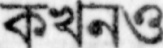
কখনও
